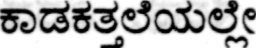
ಕಾಡಕತ್ತಲೆಯಲ್ಲೇ
